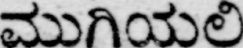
ಮುಗಿಯಲಿ
